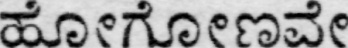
ಹೋಗೋಣವೇ
